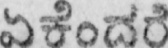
ಏಕೆಂದರೆ
